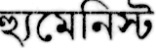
হ্যুমেনিস্ট
